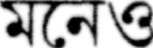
মনেও
